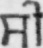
ਸੀ
